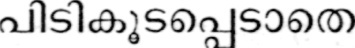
പിടികൂടപ്പെടാതെ
